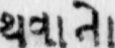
થવાનો
